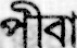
পীবা
